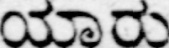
ಯಾರು
